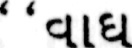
"વાઘ
